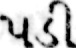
પડી
